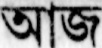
আজ
